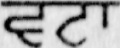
ਵਟਾ
